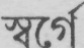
স্বৰ্গে
